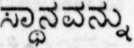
ಸ್ಥಾನವನ್ನು
